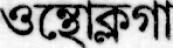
ওন্থোক্লগা
